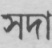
সদা
